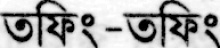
তফিং-তফিং
